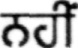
ਨਹੀਂ
